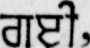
ਗਈ,
